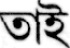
তাই
